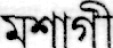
মশাগী
